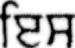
ਇਸ
